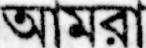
আমরা
